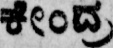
ಕೇಂದ್ರ
